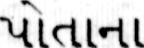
પોતાના
